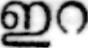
ഇറ
